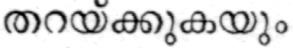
തറയ്ക്കുകയും
